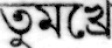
তুমখ্রে
